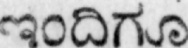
ಇಂದಿಗೂ
